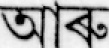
আৰু
